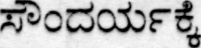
ಸೌಂದರ್ಯಕ್ಕೆ
